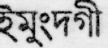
ইমুংদগী
